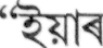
"ইয়াৰ
